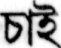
চাই
